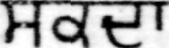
ਸਕਦਾ
